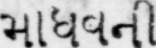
માધવની
